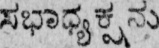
ಸಭಾಧ್ಯಕ್ಷನು
